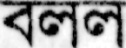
বলল
